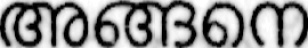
അങ്ങനെ
